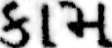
કામ
